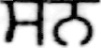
ਸਨ
